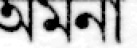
অমনা
